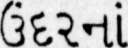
ઉંદરનાં
